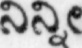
ನಿನ್ನೀ
